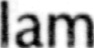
lam
